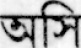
অসি
